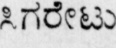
ಸಿಗರೇಟು
